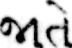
જાતે
